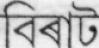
বিৰাট
